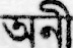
অনী
